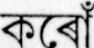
কৰোঁ
